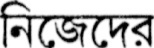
নিজেদের
